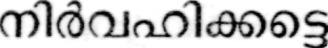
നിര്‍വഹിക്കട്ടെ
